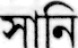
সানি
